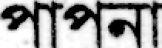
পাপনা
